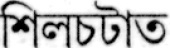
শিলচটাত
